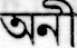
অনী
